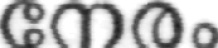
നേരം
